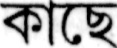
কাছে
